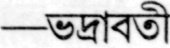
–ভদ্রাবতী
